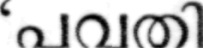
'പവതി
